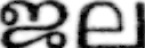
ജല
